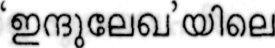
'ഇന്ദുലേഖ'യിലെ
